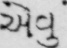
એવું
